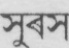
সুৰস
